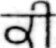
ਕੀ
